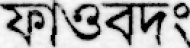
ফাওবদং
